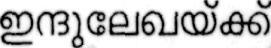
ഇന്ദുലേഖയ്ക്ക്
